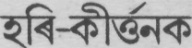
হৰি-কীৰ্ত্তনক
